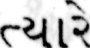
ત્યારે
